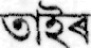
তাইৰ
